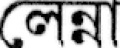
লেন্না
